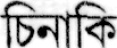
চিনাকি
